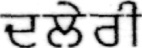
ਦਲੇਰੀ
